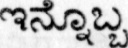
ಇನ್ನೊಬ್ಬ
